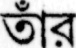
তাঁর
